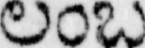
ಲಂಬ
